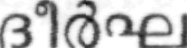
ദീര്‍ഘ
